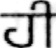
ਹੀ
